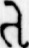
તે
